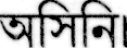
অসিনি।
